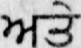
ਅਤੇ
